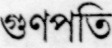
গুণপতি
